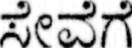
ಸೇವೆಗೆ
